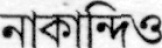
নাকান্দিও
